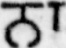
ਨਾ
